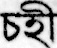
চহী
